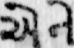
એને
